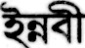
ইন্নবী
